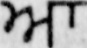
ਆ
